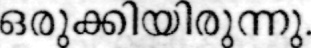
ഒരുക്കിയിരുന്നു.
